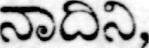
ನಾದಿನಿ,
